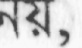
নয়,
